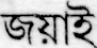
জয়াই
